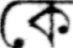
কে
